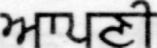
ਆਪਣੀ
